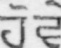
ਹੋਵੇ
